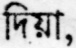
দিয়া,
